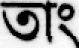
তাং
